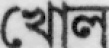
খোল
